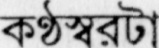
কন্ঠস্বরটা
